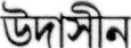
উদাসীন
